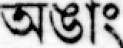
অঙাং
